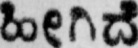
ಹೀಗಿದೆ
